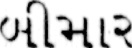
બીમાર
